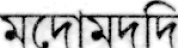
মদোমদদি
